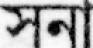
সনা
